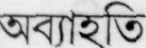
অব্যাহতি
